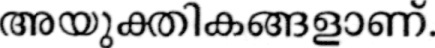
അയുക്തികങ്ങളാണ്.
